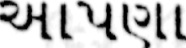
આપણા
